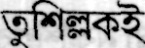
তুশিল্লকই
